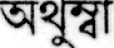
অথুম্বা
